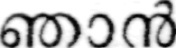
ഞാന്‍
